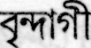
বৃন্দাগী
